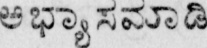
ಅಭ್ಯಾಸಮಾಡಿ
